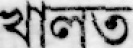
খালত
